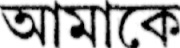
আমাকে
